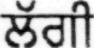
ਲੱਗੀ
